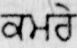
ਕਮਰੇ
